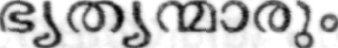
ഭൃത്യന്മാരും
